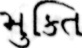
મુક્તિ
